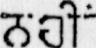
ਨਹੀਂ
